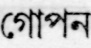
গোপন
